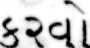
કરવો
